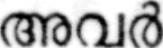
അവര്‍
